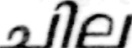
ചില
